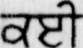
ਕਈ
